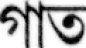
গাত
